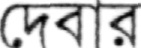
দেবার
